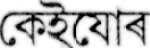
কেইযোৰ
